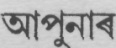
আপুনাৰ
